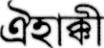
ঐহাক্কী
